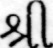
શ્રી
